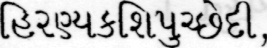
હિરણ્યકશિપુચ્છેદી,
